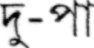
দু-পা
